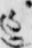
હું
